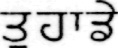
ਤੁਹਾਡੇ
